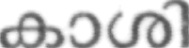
കാശി
